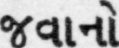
જવાનો
